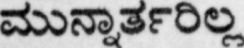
ಮುನ್ನಾರ್ತರಿಲ್ಲ
